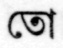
তো
